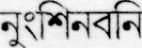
নুংশিনবনি
